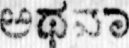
ಅಥವಾ
